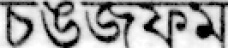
চঙজফম
